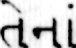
તેનાં
